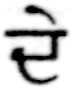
ਦੇ
